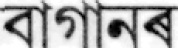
বাগানৰ
